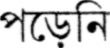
পড়েনি
